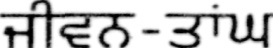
ਜੀਵਨ-ਤਾਂਘ
